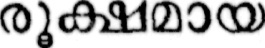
രൂക്ഷമായ
